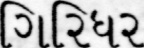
ગિરિધર
